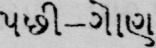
પછી-ગોણ
